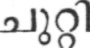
ചുറ്റി
